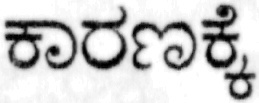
ಅದರ
